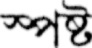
স্পষ্ট
